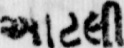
આટલી
